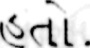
હતો.
